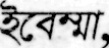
ইবেম্মা,
